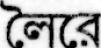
লৈরে
